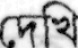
দেখি
